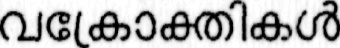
വക്രോക്തികള്‍
